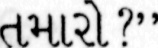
તમારો?"
